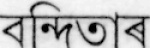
বন্দিতাৰ
